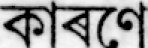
কাৰণে
